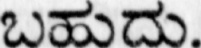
ಬಹುದು.
